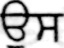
ਉਸ
